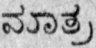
ಮಾತ್ರ
